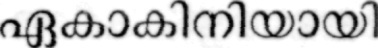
ഏകാകിനിയായി
